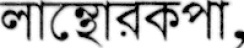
লান্থোরকপা,
